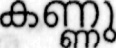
കണ്ണു
